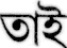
তাই
